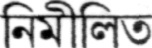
নিমীলিত
